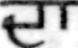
ਦਾ
